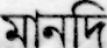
মানদি
